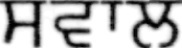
ਸਵਾਲ
